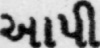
આપી
